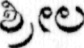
ಶ್ರೀಲ
